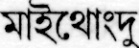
মাইথোংদু
